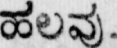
ಹಲವು.
